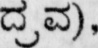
ದ್ರವ),
